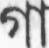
গা
